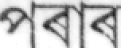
পৰাৰ
